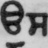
ਉਸ
